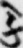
કે
